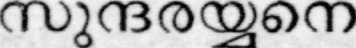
സുന്ദരയ്യനെ
